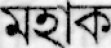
মহাক
